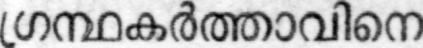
ഗ്രന്ഥകര്‍ത്താവിനെ
